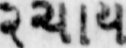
રચાય
